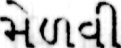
મેળવી
